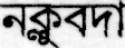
নক্লুবদা
